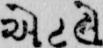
એટલે
